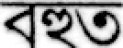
বহুত
